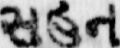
સહન
